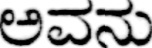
ಅವನು
